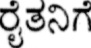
ರೈತನಿಗೆ
